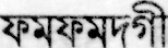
ফমফমদগী
